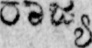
ರಾಜ್ಯ
